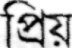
প্রিয়
